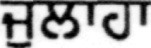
ਜੁਲਾਹਾ
